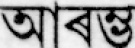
আৰম্ভ
